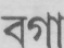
বগা
